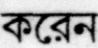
করেন
